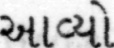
આવ્યો
